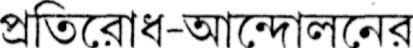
প্রতিরোধ-আন্দোলনের
